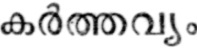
കര്‍ത്തവ്യം
